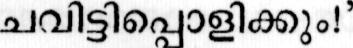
ചവിട്ടിപ്പൊളിക്കും!'
